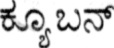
ಕ್ಯೂಬನ್
